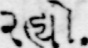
રહ્યો.
